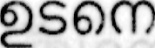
ഉടനെ
